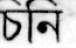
চিনি
